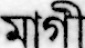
মাগী
